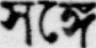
সঙ্গে
